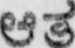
ಆತ
